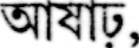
আষাঢ়,
